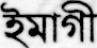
ইমাগী
